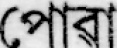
পোৱা
